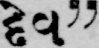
દેવ”
